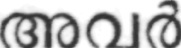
അവര്‍
